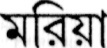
মরিয়া
